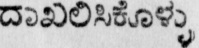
ದಾಖಲಿಸಿಕೊಳ್ಳು
